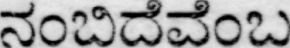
ನಂಬಿದೆವೆಂಬ
